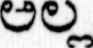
ಅಲ್ಲ
